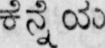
ಕೆನ್ನೆಯ
